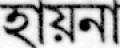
হায়না
